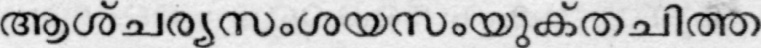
ആശ്ചര്യസംശയസംയുക്തചിത്ത
